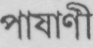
পাষাণী
